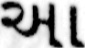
આ
